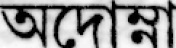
অদোম্না
